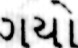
ગયો
